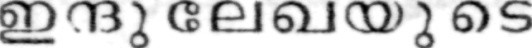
ഇന്ദുലേഖയുടെ
